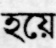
হয়ে
